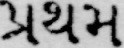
પ્રથમ
